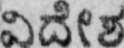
ವಿದೇಶ
